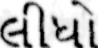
લીધો
